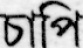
চাপি
